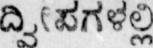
ದ್ವೀಪಗಳಲ್ಲಿ
